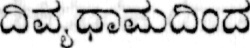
ದಿವ್ಯಧಾಮದಿಂದ
